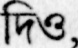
দিও,
